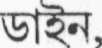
ডাইন,
